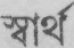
স্বাৰ্থ
